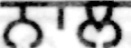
ਨਾਲ
